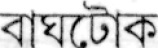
বাঘটোক
